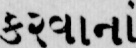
કરવાનાં
